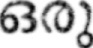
ഒരു
